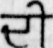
ਦੀ
